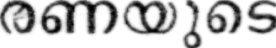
രണയുടെ
